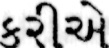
કરીએ
